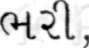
ભરી,
